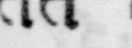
સતત
